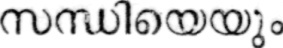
സന്ധിയെയും
